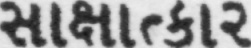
સાક્ષાત્કાર
